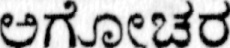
ಅಗೋಚರ
